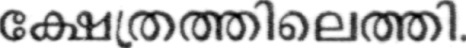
ക്ഷേത്രത്തിലെത്തി.
